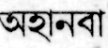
অহানবা
